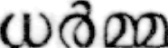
ധര്‍മ്മ
